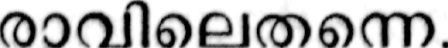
രാവിലെതന്നെ.
